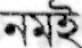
নমই
